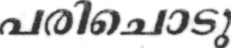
പരിചൊടു
